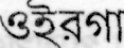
ওইরগা
